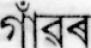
গাঁৱৰ
